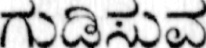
ಗುಡಿಸುವ
